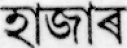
হাজাৰ
